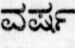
ವರ್ಷ
